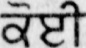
ਕੋਈ
